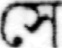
সে
